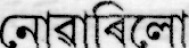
নোৱাৰিলো
